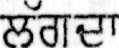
ਲੱਗਦਾ
